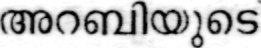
അറബിയുടെ
